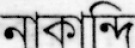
নাকান্দি
